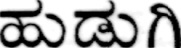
ಹುಡುಗಿ
